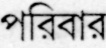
পরিবার
